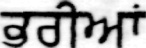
ਭਰੀਆਂ
